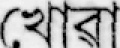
খোৱা
